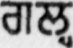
ਗਲ੍ਹ
